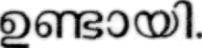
ഉണ്ടായി.
